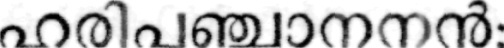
ഹരിപഞ്ചാനനന്‍:
